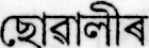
ছোৱালীৰ
